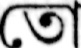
তো
